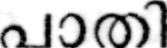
പാതി
